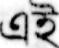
এই
